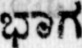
ಭಾಗ
